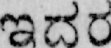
ಇದರ
